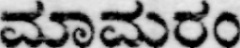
ಮಾಮರಂ
